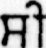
ਸੀ
